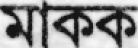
মাকক
